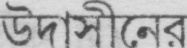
উদাসীনের
